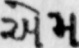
એમ
